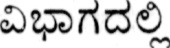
ವಿಭಾಗದಲ್ಲಿ
